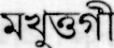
মখুত্তগী
